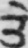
ਤੇ
